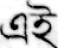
এই
